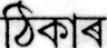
ঠিকাৰ
